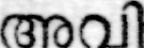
അവി
